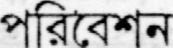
পরিবেশন
